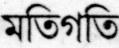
মতিগতি
